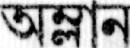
অম্লান
